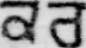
ਕਰ
